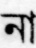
না
